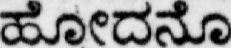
ಹೋದನೊ
